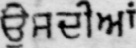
ਉਸਦੀਆਂ
